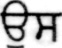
ਉਸ
